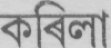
কৰিলা
